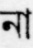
না
